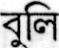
বুলি
